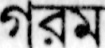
গরম
